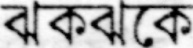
ঝকঝকে
